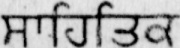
ਸਾਹਿਤਿਕ
